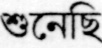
শুনেছি
